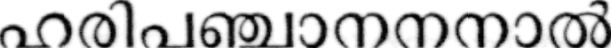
ഹരിപഞ്ചാനനനാല്‍
